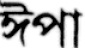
ঈপা
